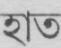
হাত
